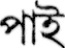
পাই
